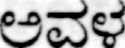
ಅವಳ
